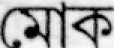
মোক
